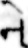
ને
